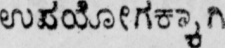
ಉಪಯೋಗಕ್ಕಾಗಿ
